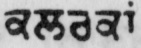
ਕਲਰਕਾਂ
